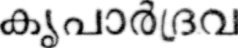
കൃപാര്‍ദ്രവ
